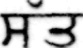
ਸੱਤ
